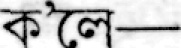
ক'লে-
